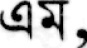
এম,
